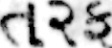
તરફ
